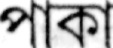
পাকা
